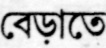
বেড়াতে
